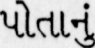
પોતાનું
